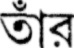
তাঁর
